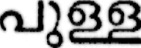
പുള്ള
